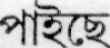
পাইছে
